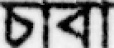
চাবা
